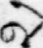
જે
